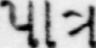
પાત્ર
